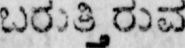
ಬರುತ್ತಿರುವ
